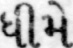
ધીમે
